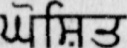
ਘੋਸ਼ਿਤ
